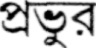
প্রভুর
